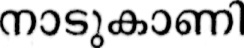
നാടുകാണി
